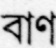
বাণ
